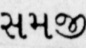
સમજી
